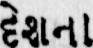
દેશના
